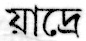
য়াদ্রে
